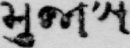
મુજાબ
